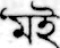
'মই
